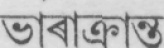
ভাৰাক্ৰান্ত
